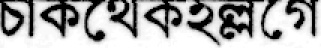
চাকথেকহল্লগে
